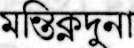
মন্তিক্নদুনা
